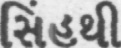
સિંહથી
